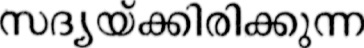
സദ്യയ്ക്കിരിക്കുന്ന
